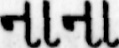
નાના
